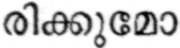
രിക്കുമോ
